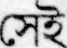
সেই
